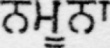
ਨਮੂਨਾ
